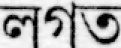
লগত
